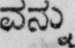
ವನ್ನು
